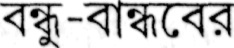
বন্ধু-বান্ধবের
